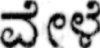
ವೇಳೆ
